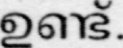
ഉണ്ട്.
